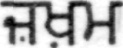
ਜ਼ਖ਼ਮ
